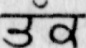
ਤੱਕ
